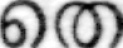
തെ
